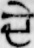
ਦੇ
